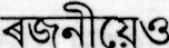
ৰজনীয়েও
